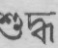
শুদ্ধ
